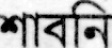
শাবনি
